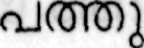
പത്തു
